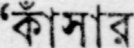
‘কাঁসার
